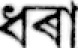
ধৰা
